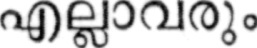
എല്ലാവരും
